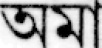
অমা
